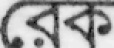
রেক
